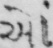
ઓં
